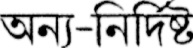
অন্য-নির্দিষ্ট
